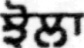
ਝੋਲਾ
